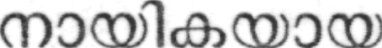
നായികയായ
